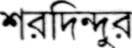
শরদিন্দুর
